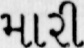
મારી
